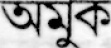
অমুক
